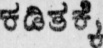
ಕಡಿತಕ್ಕೆ
